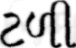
ટળી
